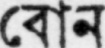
বোন
